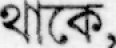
থাকে,
